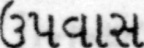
ઉપવાસ
